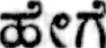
ಹೇಗೆ
